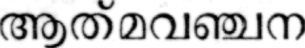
ആത്മവഞ്ചന
